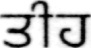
ਤੀਹ
